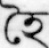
হৈ
